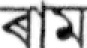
ৰাম
